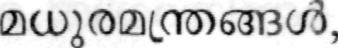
മധുരമന്ത്രങ്ങള്‍,
